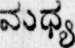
ಮಧ್ಯ
